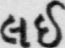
લઈ
